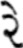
રે
